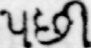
પછી
